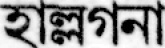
হাল্লগনা
